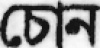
চোন
